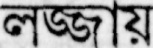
লজ্জায়
